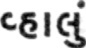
વ્હાલું
